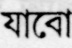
যাবো
